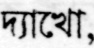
দ্যাখো,
